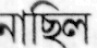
নাছিল
